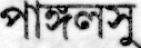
পাঙ্গলসু
